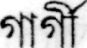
গার্গী
